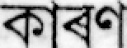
কাৰণ
